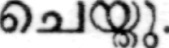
ചെയ്തു.
